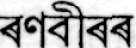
ৰণবীৰৰ
